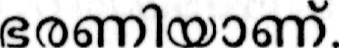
ഭരണിയാണ്.
